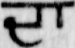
ਦਾ
